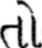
તો
